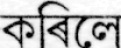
কৰিলে
